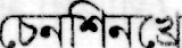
চেনশিনখ্রে
